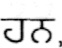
ਹਨ,
